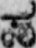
ಪ
